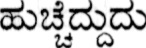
ಹುಚ್ಚೆದ್ದುದು
